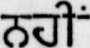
ਨਹੀਂ
